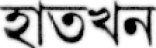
হাতখন
